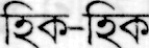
হিক-হিক
